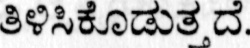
ತಿಳಿಸಿಕೊಡುತ್ತದೆ.
